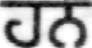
ਹਨ
